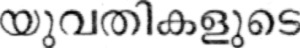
യുവതികളുടെ
